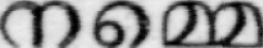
നമ്മെ
